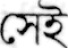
সেই
